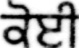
ਕੋਈ
